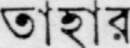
তাহার
